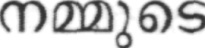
നമ്മുടെ
